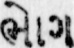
ભોગ
